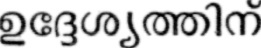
ഉദ്ദേശ്യത്തിന്
